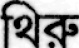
থিরু
